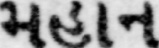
મહાન
